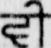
ਵੀ
